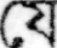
যে
